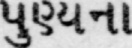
પુણ્યના
